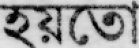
হয়তো
